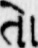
તો
